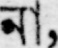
না,
